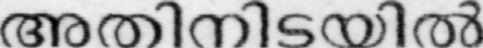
അതിനിടയില്‍
